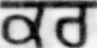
ਕਰ
